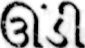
ઊંડી
